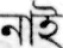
নাই
